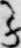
કે
